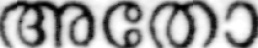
അതോ
